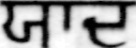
ਯਾਦ
